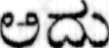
ಅದು
